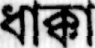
ধাক্কা
